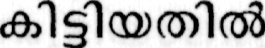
കിട്ടിയതില്‍
